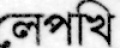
লেপখি
